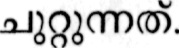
ചുറ്റുന്നത്.
